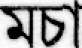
মচা
